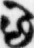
છે
